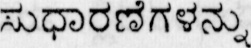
ಸುಧಾರಣೆಗಳನ್ನು
